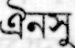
ঐনসু
